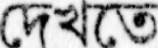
দেখতে
